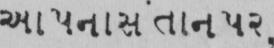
આપનાસંતાનપર,
